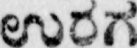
ಉರಗ
